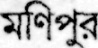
মণিপুরা
